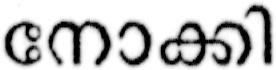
നോക്കി
